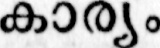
കാര്യം
